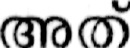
അത്
